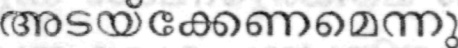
അടയ്ക്കേണമെന്നു
